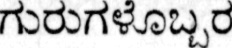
ಗುರುಗಳೊಬ್ಬರ
